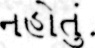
નહોતું.
